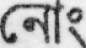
নোং
